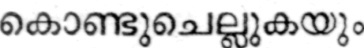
കൊണ്ടുചെല്ലുകയും
